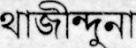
থাজীন্দুনা
